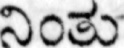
ನಿಂತು
